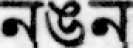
নঙন
